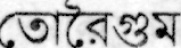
তোরৈগুম
